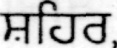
ਸ਼ਹਿਰ,
